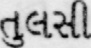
તુલસી
